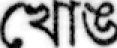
খোঙ
